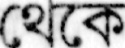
থেকে
